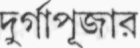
দুর্গাপূজার
